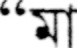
“মা
